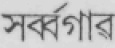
সৰ্ব্বগাৱ
